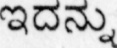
ಇದನ್ನು
